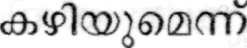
കഴിയുമെന്ന്
